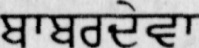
ਬਾਬਰਦੇਵਾ
